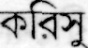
করিসু
